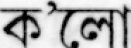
ক'লো
